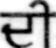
ਦੀ
